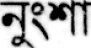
নুংশা
